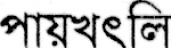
পায়খৎলি
